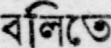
বলিতে
